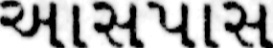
આસપાસ
